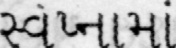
સ્વપ્નામાં
